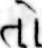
તો
